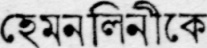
হেমনলিনীকে
